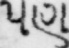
પણ
